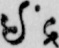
ઇંદ્ર
